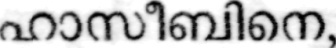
ഹാസീബിനെ,
